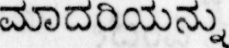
ಮಾದರಿಯನ್ನು
